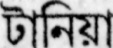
টানিয়া
